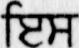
ਇਸ
